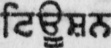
ਟਿਊਸ਼ਨ
